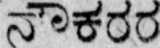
ನೌಕರರ
